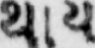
થાય
